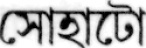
সোহাটো
